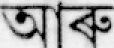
আৰু
